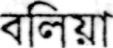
বলিয়া
